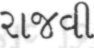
રાજવી
